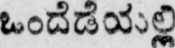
ಒಂದೆಡೆಯಲ್ಲಿ
